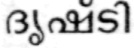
ദൃഷ്ടി
